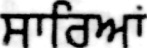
ਸਾਰਿਆਂ
